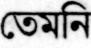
তেমনি
